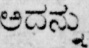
ಅದನ್ನು
